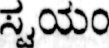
ಸ್ವಯಂ
